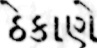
ઠેકાણે
